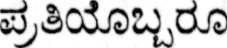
ಪ್ರತಿಯೊಬ್ಬರೂ
